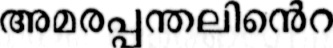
അമരപ്പന്തലിന്റെ
